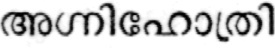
അഗ്നിഹോത്രി
